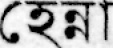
হেন্না
